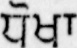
ਧੋਖਾ
